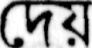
দেয়
